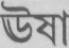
ঊষা
